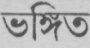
ভঙ্গিত
